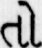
તો
